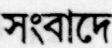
সংবাদে
